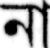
না
